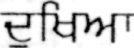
ਦੁਖਿਆ
